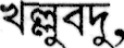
খল্লুবদু,
